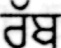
ਰੱਬ
